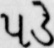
પડે
